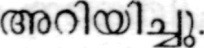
അറിയിച്ചു.
